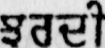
ਝਰਦੀ
